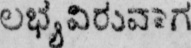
ಲಭ್ಯವಿರುವಾಗ
